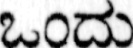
ಒಂದು
